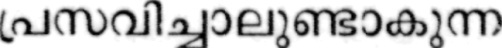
പ്രസവിച്ചാലുണ്ടാകുന്ന
